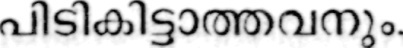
പിടികിട്ടാത്തവനും.
